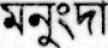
মনুংদা
